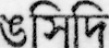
ঙসিদি
